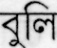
বুলি
